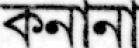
কনানা
